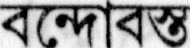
বন্দোবস্ত
